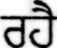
ਰਹੈ
